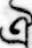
ঐ
